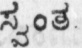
ಸ್ವಂತ
